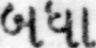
બધા
